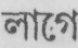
লাগে
